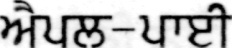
ਐਪਲ-ਪਾਈ
